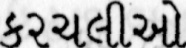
કરચલીઓ
